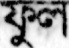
ফুল
